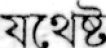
যথেষ্ট
